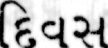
દિવસ
